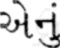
એનું
